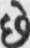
છે
